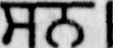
ਸਨ।
